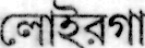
লোইরগা
